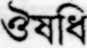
ঔষধি
